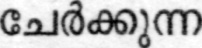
ചേര്‍ക്കുന്ന
